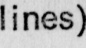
lines)
